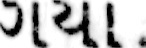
ગયા.
